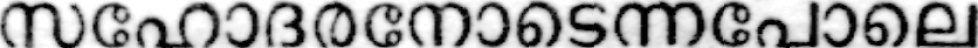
സഹോദരനോടെന്നപോലെ
